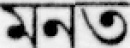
মনত
